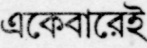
একেবারেই
